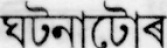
ঘটনাটোৰ
